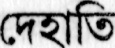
দেহাতি
